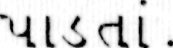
પાડતાં.
